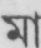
মা
